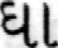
ઘા
